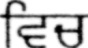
ਵਿਚ
